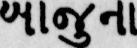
બાજુના
